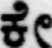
ಕೇ
